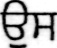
ਉਸ
